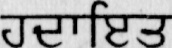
ਹਦਾਇਤ
